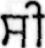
ਸੀ
